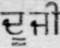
ਦੂਜੀ
